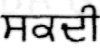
ਸਕਦੀ
